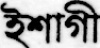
ইশাগী
